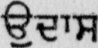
ਉਦਾਸ
